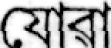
যোৱা
